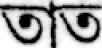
তাত
